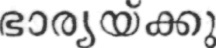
ഭാര്യയ്ക്കു
